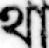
থা
